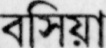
বসিয়া
